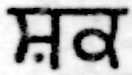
ਸ਼ਕ
